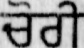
ਚੋਰੀ
